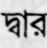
দ্বার
